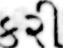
કરી
